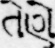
તેણે
